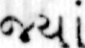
જ્યાં
